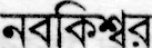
নবকিশ্বর
